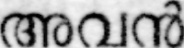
അവന്‍
